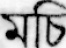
মচি
